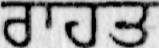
ਰਾਹਤ
